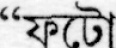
"ফটো
